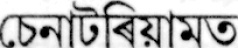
চেনাটৰিয়ামত
